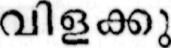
വിളക്കു
